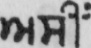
ਅਸੀਂ
